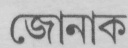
জোনাক
